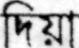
দিয়া
